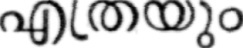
എത്രയും
